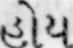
હોય
